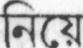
নিয়ে
